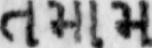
તમામ
